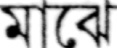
মাঝে
